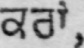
ਕਰਾਂ,
